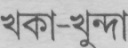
খকা-খুন্দা
